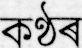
কণ্ঠৰ
